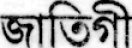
জাতিগী
